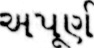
અપૂર્ણ
